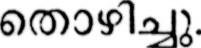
തൊഴിച്ചു.
